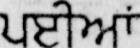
ਪਈਆਂ
